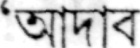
‘আদাব
